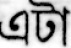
এটা
